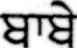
ਬਾਬੇ
